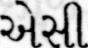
એસી
